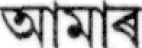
আমাৰ
